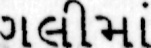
ગલીમાં
